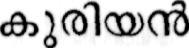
കുരിയന്‍
